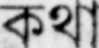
কথা
